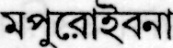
মপুরোইবনা
